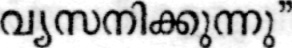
വ്യസനിക്കുന്നു”
